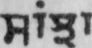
ਸਾਂਝਾ
